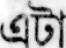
এটা
